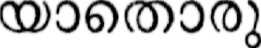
യാതൊരു
